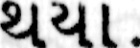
થયા.
